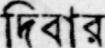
দিবার
